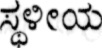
ಸ್ಥಳೀಯ
